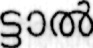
ട്ടാല്‍
